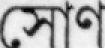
সোণ
